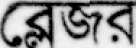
ব্লেজর
